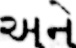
અને
